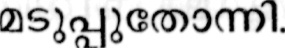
മടുപ്പുതോന്നി.
